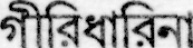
গীরিধারিনা
